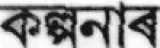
কল্পনাৰ
